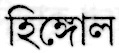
হিঙ্গোল
